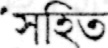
সহিত
